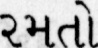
રમતો
